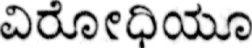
ವಿರೋಧಿಯೂ
